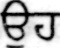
ਉਹ
